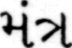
મંત્ર
